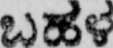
ಬಹಳ
